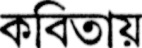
কবিতায়
